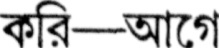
করি-আগে
